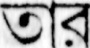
তার
